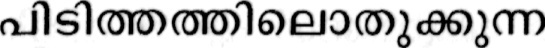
പിടിത്തത്തിലൊതുക്കുന്ന
